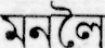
মনলৈ
